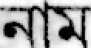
নাম
